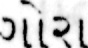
ગોરા
